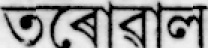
তৰোৱাল
